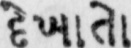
દેખાતો
